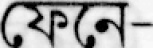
ফেনে-
